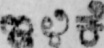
ಇಳಿಕೆ
